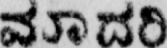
ಮಾದರಿ
